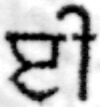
ਈ
